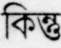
কিন্তু
